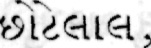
છોટેલાલ,
